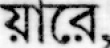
য়ারে,
